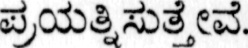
ಪ್ರಯತ್ನಿಸುತ್ತೇವೆ.
